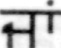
ਜਾਂ
